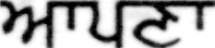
ਆਪਣਾ
